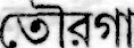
তৌরগা
